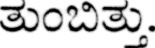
ತುಂಬಿತ್ತು.
